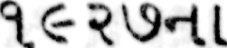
૧૯૨૭ના
